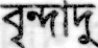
বৃন্দাদু
